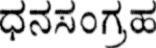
ಧನಸಂಗ್ರಹ
